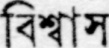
বিশ্বাস
